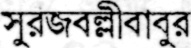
সুরজবল্লীবাবুর
